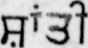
ਸ਼ਾਂਤੀ
